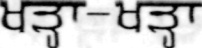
ਖੜ੍ਹਾ-ਖੜ੍ਹਾ
